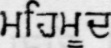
ਮਹਿਮੂਦ
